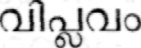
വിപ്ലവം
